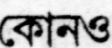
কোনও
